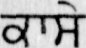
ਕਾਸੇ
